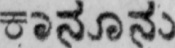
ಕಾನೂನು
